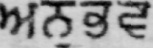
ਅਨੁਭਵ
